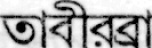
তাবীরব্রা
